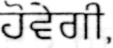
ਹੋਵੇਗੀ,
